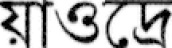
য়াওদ্রে
